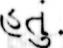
હતું.
